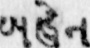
બહેન
